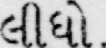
લીધો.
